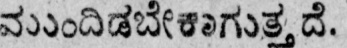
ಮುಂದಿಡಬೇಕಾಗುತ್ತದೆ.
